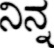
ನಿನ್ನ
